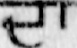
ਦਾ
